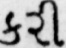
કરી
